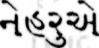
નેહરુએ
